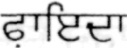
ਫ਼ਾਇਦਾ
